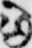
છે
